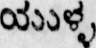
ಯುಳ್ಳ
